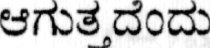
ಆಗುತ್ತದೆಂದು
